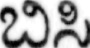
ಬಿಸಿ
